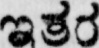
ಇತರ
